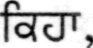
ਕਿਹਾ,
